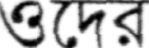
ওদের
